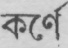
কৰ্ণে
